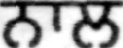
ਨਾਲ
